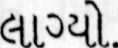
લાગ્યો.
